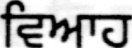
ਵਿਆਹ
